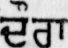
ਦੌਰਾ
